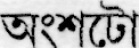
অংশটো
